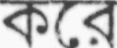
করে
